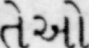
તેઓ
